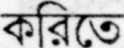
করিতে
